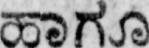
ಹಾಗೂ
